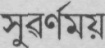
সুৱৰ্ণময়
